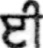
ਈ
